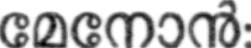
മേനോന്‍:
